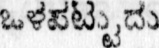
ಒಳಪಟ್ಟುದು
